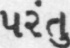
પરંતુ
